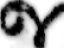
જ
